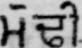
ਮੋਢੀ
